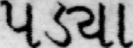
પડ્યા
